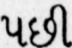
પછી
